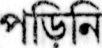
পড়িনি
